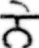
ਨੇ
